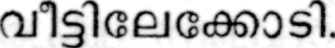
വീട്ടിലേക്കോടി.
